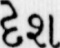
દેશ
